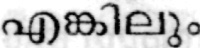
എങ്കിലും
